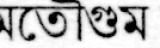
মতৌগুম
